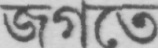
জগতে
